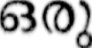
ഒരു
